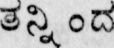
ತನ್ನಿಂದ
